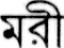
মরী
